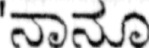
‘ನಾನೂ
